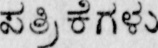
ಪತ್ರಿಕೆಗಳು
